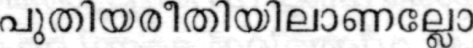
പുതിയരീതിയിലാണല്ലോ
